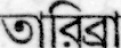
তারিব্রা
